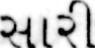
સારી
